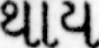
થાય
